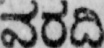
ವರದಿ
